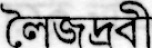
লৈজদ্রবী
